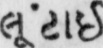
લૂંટાઈ
